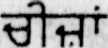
ਚੀਜ਼ਾਂ
